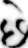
છે
